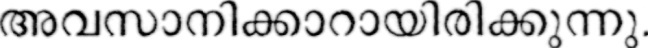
അവസാനിക്കാറായിരിക്കുന്നു.
